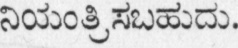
ನಿಯಂತ್ರಿಸಬಹುದು.
